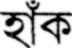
হাঁক
